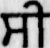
ਸੀ
